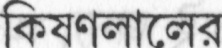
কিষণলালের
